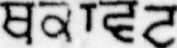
ਥਕਾਵਟ
